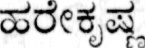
ಹರೇಕೃಷ್ಣ
